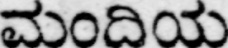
ಮಂದಿಯ
